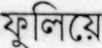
ফুলিয়ে
